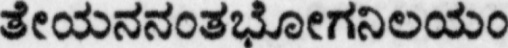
ತೇಯನನಂತಭೋಗನಿಲಯಂ
